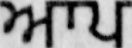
ਆਪ
